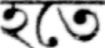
হতে
